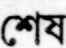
শেষ
